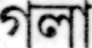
গলা
